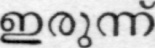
ഇരുന്ന്
